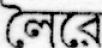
লৈরে
